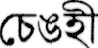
চেংহী
